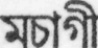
মচাগী
